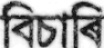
বিচাৰি
